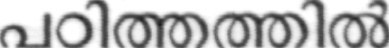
പഠിത്തത്തില്‍
